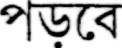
পড়বে
